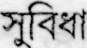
সুবিধা
